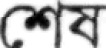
শেষ
